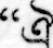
“ঐ
